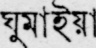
ঘুমাইয়া
